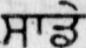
ਸਾਡੇ
